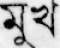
মুখ
